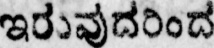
ಇರುವುದರಿಂದ
